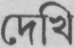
দেখি
